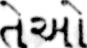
તેઓ
